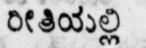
ರೀತಿಯಲ್ಲಿ
